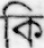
কি
